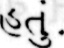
હતું.
